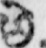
છે.
